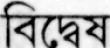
বিদ্বেষ
